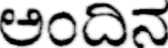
ಅಂದಿನ
